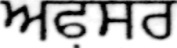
ਅਫ਼ਸਰ
